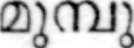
മുമ്പു
